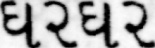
ઘરઘર
